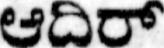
ಆದಿರ್
